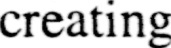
Creating
